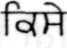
ਕਿਸੇ
